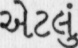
એટલું
